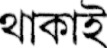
থাকাই
